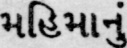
મહિમાનું
